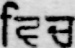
ਵਿਚ
